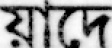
য়াদে
